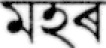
মহৰ
